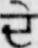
ਦੇ
